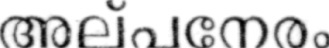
അല്പനേരം
